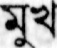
মুখ
